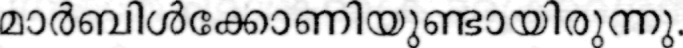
മാര്‍ബിള്‍ക്കോണിയുണ്ടായിരുന്നു.
